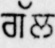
ਗੱਲ
